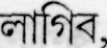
লাগিব,
